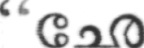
"ഛേ
